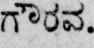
ಗೌರವ.
